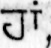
ਹਾਂ,
